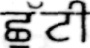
ਛੁੱਟੀ
